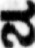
ನ
